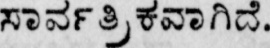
ಸಾರ್ವತ್ರಿಕವಾಗಿದೆ.
